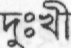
দুঃখী
